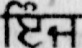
ਇੰਜ
